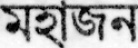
মহাজন
